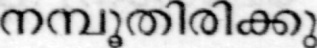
നമ്പൂതിരിക്കു
